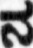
ನ
